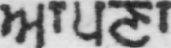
ਆਪਣਾ
